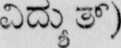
ವಿದ್ಯುತ್)
